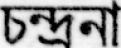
চন্দ্রনা
